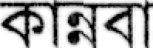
কান্নবা
